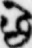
છે
